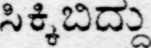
ಸಿಕ್ಕಿಬಿದ್ದು
